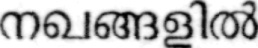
നഖങ്ങളില്‍
